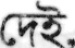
দেই,
